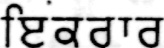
ਇਕਰਾਰ
